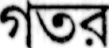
গতর
